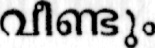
വീണ്ടും
